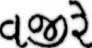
વજીરે
